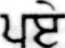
ਪਏ
